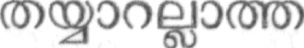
തയ്യാറല്ലാത്ത
